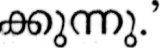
ക്കുന്നു.’
